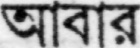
আবার
